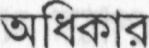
অধিকার
